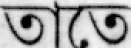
তাতে
